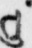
તું
